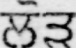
ਲੋੜ
